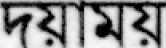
দয়াময়
